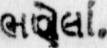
ભણેલાં.
